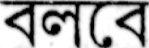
বলবে
